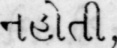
નહોતી,
